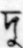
দু
